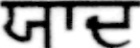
ਯਾਦ
